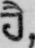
ਹੈ,
